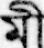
মী
